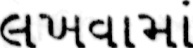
લખવામાં
